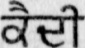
ਕੈਦੀ
